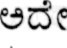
ಅದೇ
